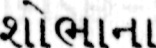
શોભાના
